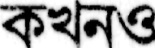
কখনও
